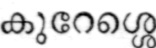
കുറേശ്ശെ
